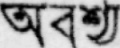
অবশ্য
